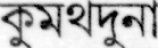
কুমথদুনা
